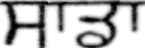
ਸਾਡਾ
